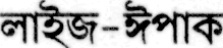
লাইজ-ঈপাক
